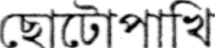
ছোটোপাখি
